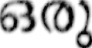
ഒരു
